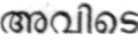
അവിടെ
